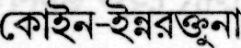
কোইন-ইন্নরক্তুনা
